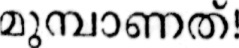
മുമ്പാണത്!
